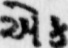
એક
